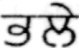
ਭਲੇ
